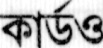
কার্ডও
